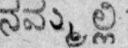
ನಮ್ಮಲ್ಲಿ
